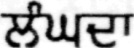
ਲੰਘਦਾ
